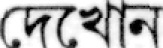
দেখোন
